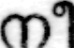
നീ
